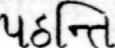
પઠન્તિ
